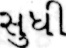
સુધી
